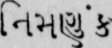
નિમણુંક
